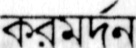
করমর্দন
